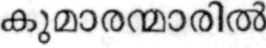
കുമാരന്മാരില്‍
